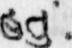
હતું.
